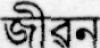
জীৱন
